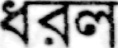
ধরল
